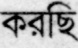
করছি
